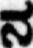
ನ
